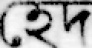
হেদ
